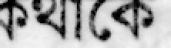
কথাকে
